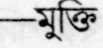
–মুক্তি
